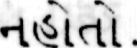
નહોતો.
